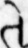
તે
